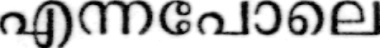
എന്നപോലെ
